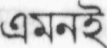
এমনই
